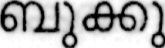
ബുക്കു
